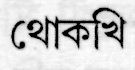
থোকখি
